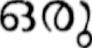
ഒരു
